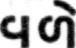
વળે
